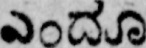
ಎಂದೂ
